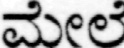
ಮೇಲೆ
